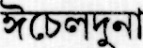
ঈচেলদুনা
